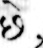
છે,
